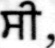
ਸੀ,
